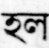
হল
